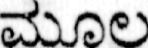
ಮೂಲ
